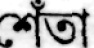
শেঁতা
